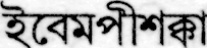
ইবেমপীশক্কা
